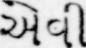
એવી
